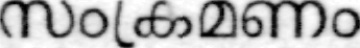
സംക്രമണം
